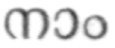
നാം
